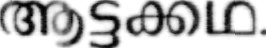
ആട്ടക്കഥ.
